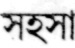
সহসা
